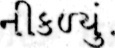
નીકળ્યું.
